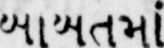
બાબતમાં
